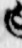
કે
